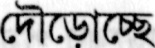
দৌড়োচ্ছে
